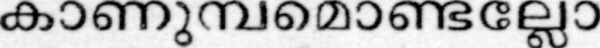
കാണുമ്പമൊണ്ടല്ലോ
